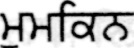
ਮੁਮਕਿਨ
